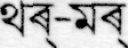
থৰ্‌-মৰ্
